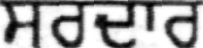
ਸਰਦਾਰ
